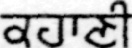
ਕਹਾਣੀ
